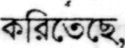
করিতেছে,
